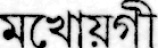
মখোয়গী
